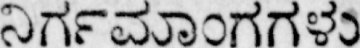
ನಿರ್ಗಮಾಂಗಗಳು
